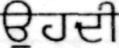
ਉਹਦੀ
